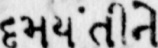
દમયંતીને
